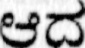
ಆದ
